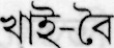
খাই-বৈ
